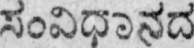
ಸಂವಿಧಾನದ
